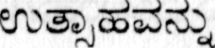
ಉತ್ಸಾಹವನ್ನು
